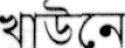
খাউনে
